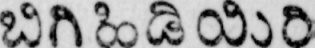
ಬಿಗಿಹಿಡಿಯಿರಿ
